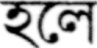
হলে
